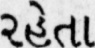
રહેતા
